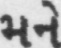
મને
